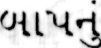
બાપનું
